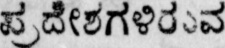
ಪ್ರದೇಶಗಳಿರುವ
